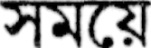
সময়ে
